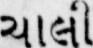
ચાલી
